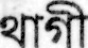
থাগী
